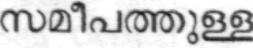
സമീപത്തുള്ള
